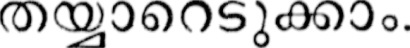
തയ്യാറെടുക്കാം.
